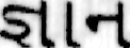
જ્ઞાન
